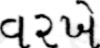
વરખે
